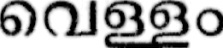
വെള്ളം
